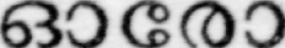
ഓരോ
